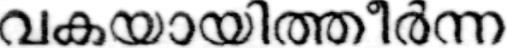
വകയായിത്തീര്‍ന്ന
